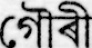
গৌৰী
